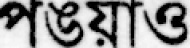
পঙয়াও
